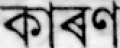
কাৰণ
